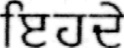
ਇਹਦੇ
